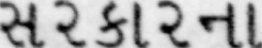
સરકારના
